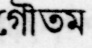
গৌতম
